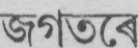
জগতৰে
